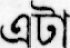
এটা
